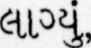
લાગ્યું,
